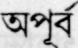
অপূর্ব
